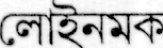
লোইনমক
